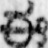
ಈ
